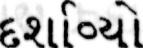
દર્શાવ્યો
